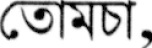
তোমচা,
